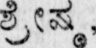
ಶ್ರೇಷ್ಠ,
